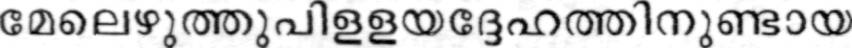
മേലെഴുത്തുപിളളയദ്ദേഹത്തിനുണ്ടായ
